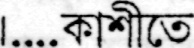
৷....কাশীতে
